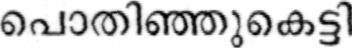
പൊതിഞ്ഞുകെട്ടി
